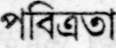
পবিত্রতা
